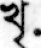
খৃ.
